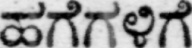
ಹಗೆಗಳಿಗೆ
